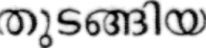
തുടങ്ങിയ
